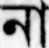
না
